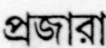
প্রজারা
